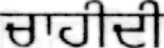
ਚਾਹੀਦੀ
